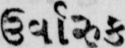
ઉર્વારુક
